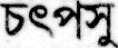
চৎপসু
